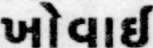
ખોવાઈ
